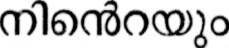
നിന്റെയും
